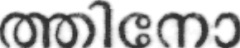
ത്തിനോ
